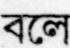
বলে
